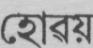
হোৱয়
